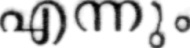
എന്നും
